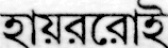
হায়ররোই
